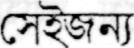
সেইজন্য
